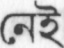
নেই
